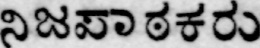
ನಿಜಪಾಠಕರು
